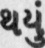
થયું
